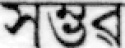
সম্ভৱ
